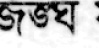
জিঙ্ঘ
